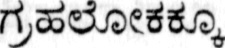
ಗ್ರಹಲೋಕಕ್ಕೂ
